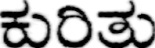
ಕುರಿತು
